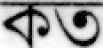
কত
